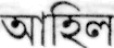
আহিল
